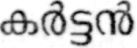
കര്‍ട്ടന്‍
